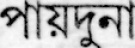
পায়দুনা
